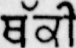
ਥੱਕੀ
